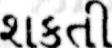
શકતી
